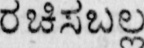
ರಚಿಸಬಲ್ಲ
